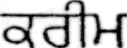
ਕਰੀਮ
